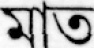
মাত
